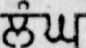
ਲੰਘ
